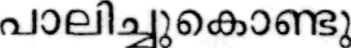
പാലിച്ചുകൊണ്ടു
